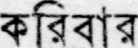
করিবার
